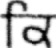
ਕਿ
